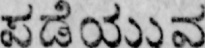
ಪಡೆಯುವ
